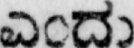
ಎಂದು
